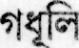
গধূলি
